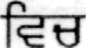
ਵਿਚ
